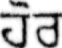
ਹੋਰ
